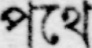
পথে
